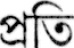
প্রতি
